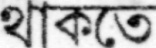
থাকতে
